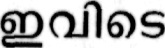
ഇവിടെ
